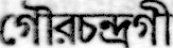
গৌরচন্দ্রগী
